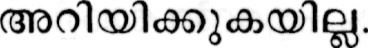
അറിയിക്കുകയില്ല.
